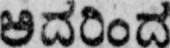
ಅದರಿಂದ
